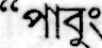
“পাবুং
